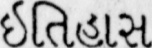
ઈતિહાસ
